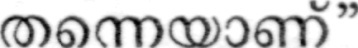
തന്നെയാണ്”
